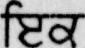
ਇਕ
